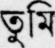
তুমি
